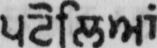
ਪਟੋਲਿਆਂ
